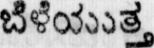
ಬೆಳೆಯುತ್ತ
